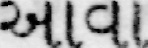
આવા
